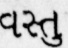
વસ્તુ'
